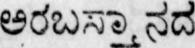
ಅರಬಸ್ತಾನದ
